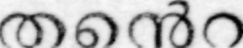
തന്റെ
